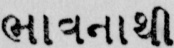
ભાવનાથી
